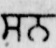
ਸਨ
